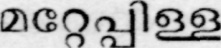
മറ്റേപ്പിള്ള
